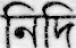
নিদি
